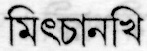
মিৎচানখি
